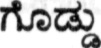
ಗೊಡ್ಡು
